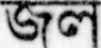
জল
